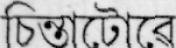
চিন্তাটোৱে
